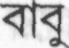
বাবু
